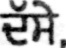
ਦੱਸੇ,
